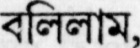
বলিলাম,
